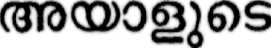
അയാളുടെ
